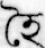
হৈ
